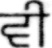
ਵੀ
